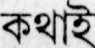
কথাই
